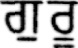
ਗੁਰੂ
